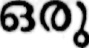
ഒരു
